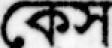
কেস
